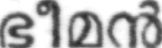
ഭീമന്‍
